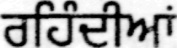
ਰਹਿੰਦੀਆਂ
